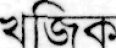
খজিক
